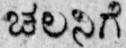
ಚಲನಿಗೆ
